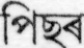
পিছৰ
